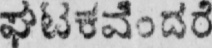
ಘಟಕವೆಂದರೆ
